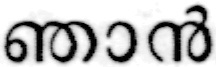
ഞാന്‍
